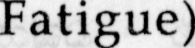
Fatigue)
